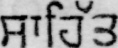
ਸਾਹਿੱਤ
